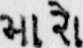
મારો
